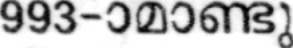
993-ാമാണ്ടു
